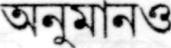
অনুমানও
